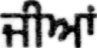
ਜੀਆਂ
